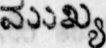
ಮುಖ್ಯ
